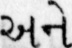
અને
